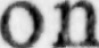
on
